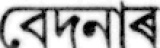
বেদনাৰ
